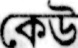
কেউ
